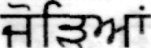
ਜੋੜਿਆਂ
